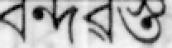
বন্দৱস্ত
